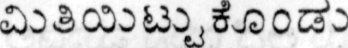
ಮಿತಿಯಿಟ್ಟುಕೊಂಡು
